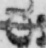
ಈ
